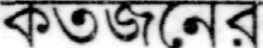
কতজনের
